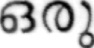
ഒരു
